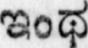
ಇಂಥ
